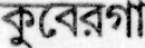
কুবেরগা
